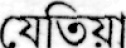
যেতিয়া
